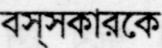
বস্সকারকে
